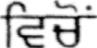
ਵਿਚੋਂ
